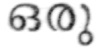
ഒരു
